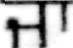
ਜਾ
